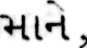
માને,
